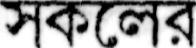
সকলের
